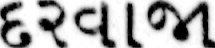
દરવાજા
